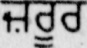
ਜ਼ਰੂਰ
